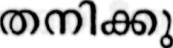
തനിക്കു
